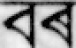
বৰ
